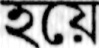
হয়ে
